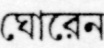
ঘোরেন
